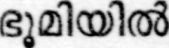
ഭൂമിയില്‍
